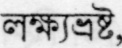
লক্ষ্যভ্রষ্ট,
